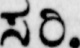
ಸರಿ.
